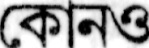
কোনও
